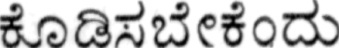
ಕೊಡಿಸಬೇಕೆಂದು
